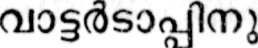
വാട്ടര്‍ടാപ്പിനു
